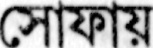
সোফায়
